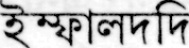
ইম্ফালদদি
